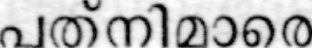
പത്നിമാരെ
